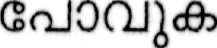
പോവുക
